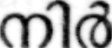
നിര്‍
